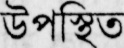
উপস্থিত
